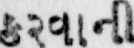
કરવાની
